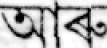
আৰু
